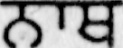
ਨਾਥ
